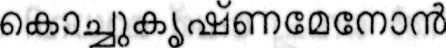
കൊച്ചുകൃഷ്ണമേനോന്‍
